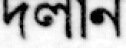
দলান
